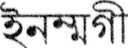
ইনম্মগী
